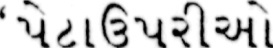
'પેટાઉપરીઓ
